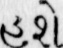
હશે
